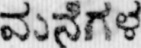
ಮನೆಗಳ
